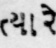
ત્યારે
